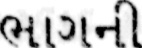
ભાગની
